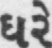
ઘરે
